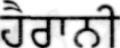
ਹੈਰਾਨੀ
